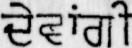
ਦੇਵਾਂਗੀ
